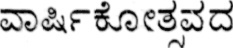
ವಾರ್ಷಿಕೋತ್ಸವದ
